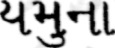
યમુના
